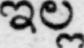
ಇಲ್ಲ
